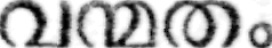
വന്മതം
